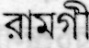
রামগী
